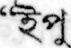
“ইপু
